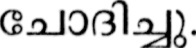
ചോദിച്ചു.
